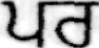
ਪਰ
